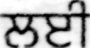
ਲਈ
